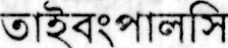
তাইবংপালসি
